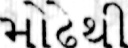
મોઢેથી
